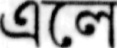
এলে
